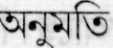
অনুমতি
